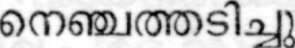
നെഞ്ചത്തടിച്ചു
